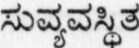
ಸುವ್ಯವಸ್ಥಿತ
